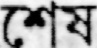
শেষ
